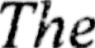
The
